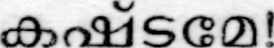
കഷ്ടമേ!
